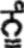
ਨੂੰ
